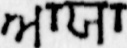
ਆਯਾ
